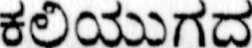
ಕಲಿಯುಗದ
